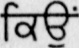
ਕਿਉਂ
